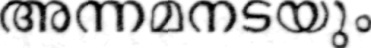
അന്നമനടയും
